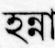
হন্না
